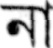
না
